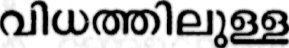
വിധത്തിലുള്ള
